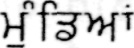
ਮੁੰਡਿਆਂ
